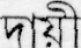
দায়ী
